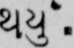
થયું.
